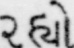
રહ્યો
